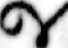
જ
